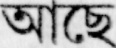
আছে
